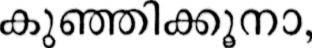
കുഞ്ഞിക്കൂനാ,
